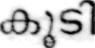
കൂടി
